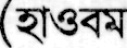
(হাওবম
